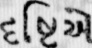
દષ્ટિએ
